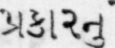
પ્રકારનું
